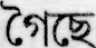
গৈছে
